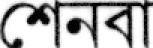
শেনবা
